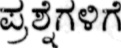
ಪ್ರಶ್ನೆಗಳಿಗೆ
